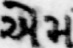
એમ
